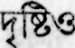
দৃষ্টিও
